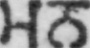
ਮਨ
